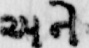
અને
